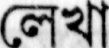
লেখা
